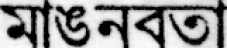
মাঙনবতা
